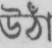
উঠাঁ
